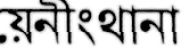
য়েংনীংথানা
